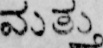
ಮತ್ತು
